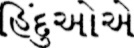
હિંદુઓએ
